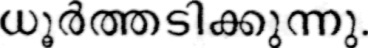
ധൂര്‍ത്തടിക്കുന്നു.
